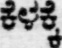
ಕೆಳಕ್ಕೆ
